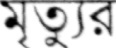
মৃত্যুর
